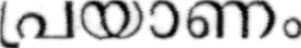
പ്രയാണം
